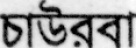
চাউরবা
